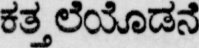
ಕತ್ತಲೆಯೊಡನೆ
